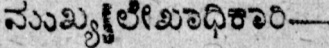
ಮುಖ್ಯಲೇಖಾಧಿಕಾರಿ-
